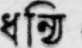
ধন্যি
